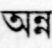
অন্ন
